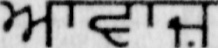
ਆਵਾਜ਼
